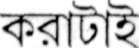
করাটাই
